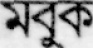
মবুক
